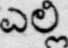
ಎಲ್ಲಿ
